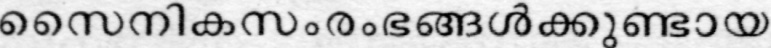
സൈനികസംരംഭങ്ങള്‍ക്കുണ്ടായ
